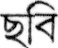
ছবি
